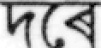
দৰে
